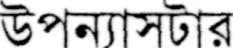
উপন্যাসটার
